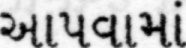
આપવામાં
